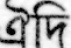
ঐদি
